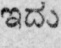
ಇದು
